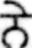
ਨੇ
